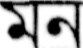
মন
